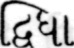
દ્વિધા
